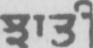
ਝਾਤੀ
